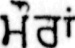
ਮੌਰਾਂ
